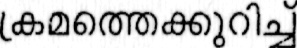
ക്രമത്തെക്കുറിച്ച്
